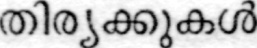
തിര്യക്കുകള്‍
